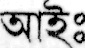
আইঃ
